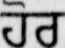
ਹੋਰ
